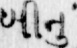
બીનું
